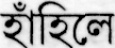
হাঁহিলে
